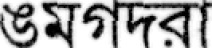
ঙমগদরা
